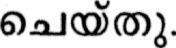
ചെയ്തു.
